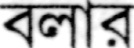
বলার
